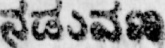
ನಡುವಣ
